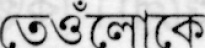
তেওঁলোকে
